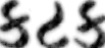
કટક
